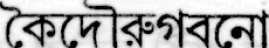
কৈদৌরুগবনো
